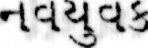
નવયુવક
